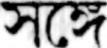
সঙ্গে
